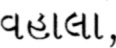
વહાલા,
